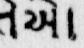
તેઓ
